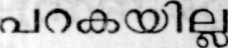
പറകയില്ല
